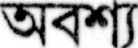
অবশ্য
